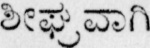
ಶೀಘ್ರವಾಗಿ
